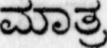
ಮಾತ್ರ
